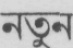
নতুন
